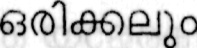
ഒരിക്കലും
